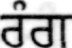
ਰੰਗ
